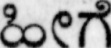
ಹೀಗೆ
